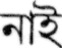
নাই
